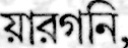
য়ারগনি,
